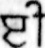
ਈ
